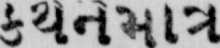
કથનમાત્ર
